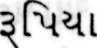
રૂપિયા
